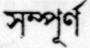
সম্পূর্ণ
